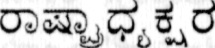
ರಾಷ್ಟ್ರಾಧ್ಯಕ್ಷರ
